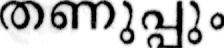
തണുപ്പും
